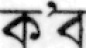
ক'ব
